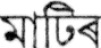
মাটিৰ
